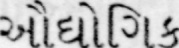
ઔધોગિક
